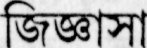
জিজ্ঞাসা
